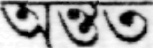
অন্তত
